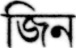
জিন
